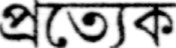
প্রত্যেক
